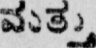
ಮತ್ತು
